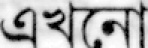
এখনো
